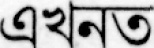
এখনত
